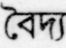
বৈদ্য
